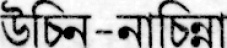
উচিন-নাচিন্না
